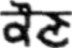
ਕੌਣ
